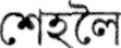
শেহলৈ
